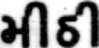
મીઠી
